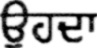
ਉਹਦਾ
